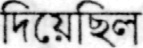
দিয়েছিল
